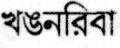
খঙনরিবা
